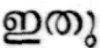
ഇതു
